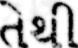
તેથી
